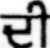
ਦੀ
